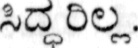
ಸಿದ್ಧರಿಲ್ಲ.
